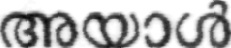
അയാള്‍
